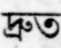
দ্রুত
